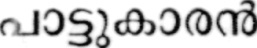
പാട്ടുകാരന്‍
